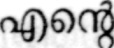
എന്റെ
